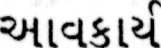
આવકાર્ય
